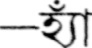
–হ্যাঁ
